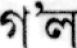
গ'ল
